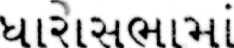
ધારાસભામાં
